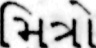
મિત્રો
